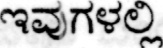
ಇವುಗಳಲ್ಲಿ
